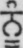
ਨੂੰ
